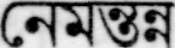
নেমন্তন্ন
